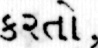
કરતો,
